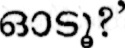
ഓടൂ?'
